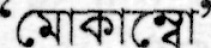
‘মোকাম্বো’
